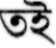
তই
